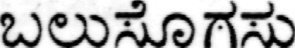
ಬಲುಸೊಗಸು
